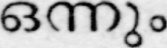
ഒന്നും
